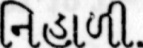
નિહાળી.
